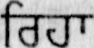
ਰਿਹਾ
